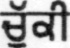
ਚੁੱਕੀ
